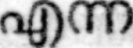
എന്ന
